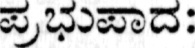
ಪ್ರಭುಪಾದ:
